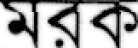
মরক
